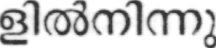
ളില്‍നിന്നു
